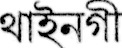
থাইনগী
